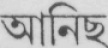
আনিছ
